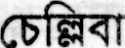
চেল্লিবা
